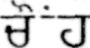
ਚੌਂਹ
